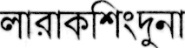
লারাকশিংদুনা
